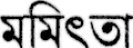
মমিৎতা
